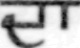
ਦਾ
